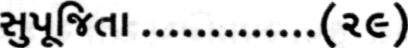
સુપૂજિતા............(૨૯)
